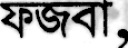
ফজবা,
